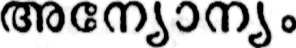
അന്യോന്യം
